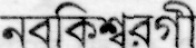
নবকিশ্বরগী
